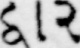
દ્વાર
